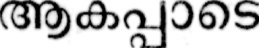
ആകപ്പാടെ
